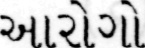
આરોગો
